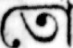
তো
